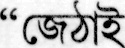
"জেঠাই
